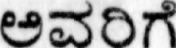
ಅವರಿಗೆ
